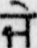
ਜੇ
